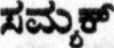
ಸಮ್ಯಕ್
